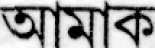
আমাক
